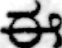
ಈ
